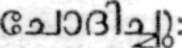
ചോദിച്ചു:
